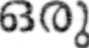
ഒരു
